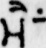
ਮੈਂ
